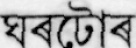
ঘৰটোৰ
